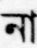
না
